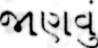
જાણવું
